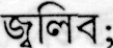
জ্বলিব;
